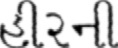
હીરની
